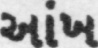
આંખ
